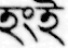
হংই
